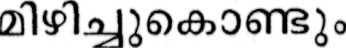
മിഴിച്ചുകൊണ്ടും
